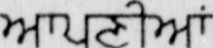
ਆਪਣੀਆਂ
